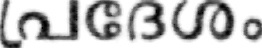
പ്രദേശം
